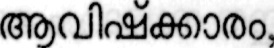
ആവിഷ്ക്കാരം,
